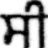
ਸੀ
